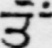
ਤੋਂ
